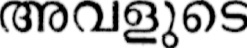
അവളുടെ
